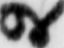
જ
